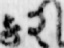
કરી
